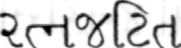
રત્નજટિત
